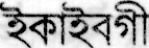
ইকাইবগী
